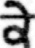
ਕੇ
